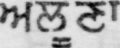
ਅਲੂਣਾ
